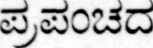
ಪ್ರಪಂಚದ
